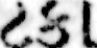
ટકા
